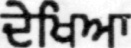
ਦੇਖਿਆ
